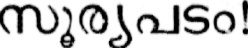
സൂര്യപടം!
